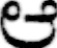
ಆ
